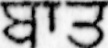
ਬਾਤ
